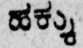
ಹಕ್ಕು
